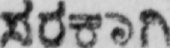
ಸರಕಾಗಿ
